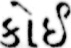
કોઈ
